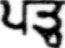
ਪੜ੍ਹ
